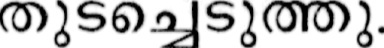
തുടച്ചെടുത്തു.
